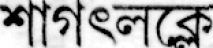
শাগৎলক্লে
